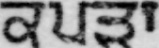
ਕਪੜਾ
